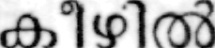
കീഴില്‍
